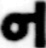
ન
